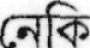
নেকি
